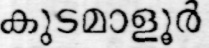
കുടമാളൂര്‍
